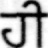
ਹੀ
